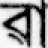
ৱা
